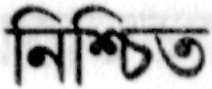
নিশ্চিত
